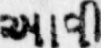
આવી
